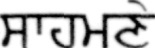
ਸਾਹਮਣੇ
